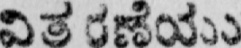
ವಿತರಣೆಯು
